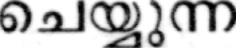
ചെയ്യുന്ന
